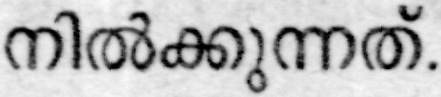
നില്‍ക്കുന്നത്.
